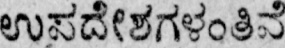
ಉಪದೇಶಗಳಂತಿವೆ
